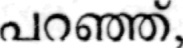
പറഞ്ഞ്,
